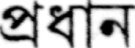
প্রধান
